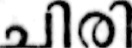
ചിരി
